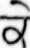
ਕੇ
